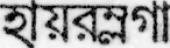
হায়রম্লগা
